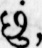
છું,
